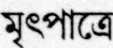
মৃত্পাত্রে
